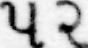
પર
